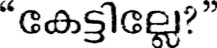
"കേട്ടില്ലേ?"
